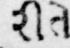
રીતે
